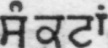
ਸੰਕਟਾਂ
